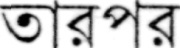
তারপর
